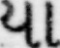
યા
